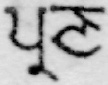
ਪ੍ਰਣ
